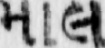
માલ
